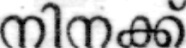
നിനക്ക്
